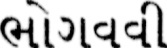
ભોગવવી
